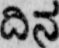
ದಿನ
